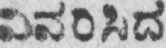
ವಿವರಿಸಿದ
